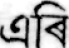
এৰি
